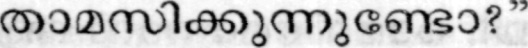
താമസിക്കുന്നുണ്ടോ?"
